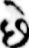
છે
